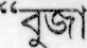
"বুজা
